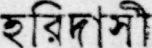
হরিদাসী
